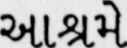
આશ્રમે
